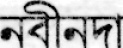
নবীনদা
